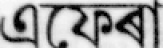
এফেৰা
